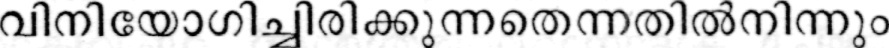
വിനിയോഗിച്ചിരിക്കുന്നതെന്നതില്‍നിന്നും
